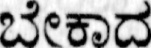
ಬೇಕಾದ
